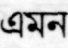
এমন
